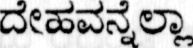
ದೇಹವನ್ನೆಲ್ಲಾ
